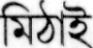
মিঠাই
